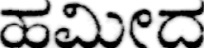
ಹಮೀದ
